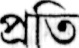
প্রতি
